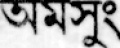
অমসুং
